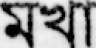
মখা
